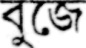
বুজে
